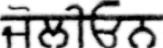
ਜੋਲੀਓਨ
